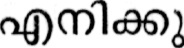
എനിക്കു
